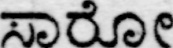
ಸಾರೋ
